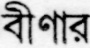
বীণার
